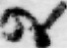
જ
